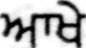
ਆਖੇ
